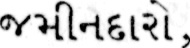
જમીનદારો,
